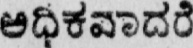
ಅಧಿಕವಾದರೆ
